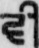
ਵੀ
